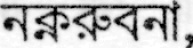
নক্নরুবনা,
